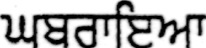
ਘਬਰਾਇਆ
